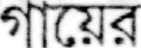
গায়ের
